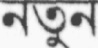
নতুন
